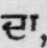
ਦਾ,
